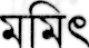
মমিৎ
